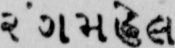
રંગમહેલ
